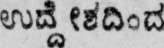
ಉದ್ದೇಶದಿಂದ
